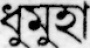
ধুমুহা
